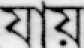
যায়
